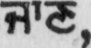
ਜਾਣ,
